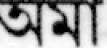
অমা
